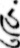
હું
